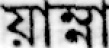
য়াম্না
